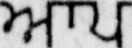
ਆਪ
